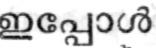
ഇപ്പോള്‍
